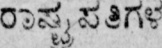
ರಾಷ್ಟ್ರಪತಿಗಳ
